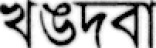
খঙদবা
